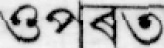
ওপৰত
